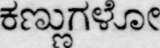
ಕಣ್ಣುಗಳೋ
